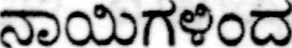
ನಾಯಿಗಳಿಂದ
